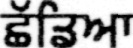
ਛੱਡਿਆ
